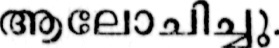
ആലോചിച്ചു.
